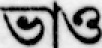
ভাও
